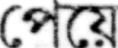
পেয়ে
